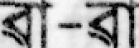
ৱা-ৱা
